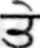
ਤੇ
